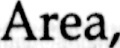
Area,
